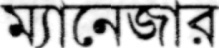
ম্যানেজার
